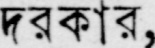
দরকার,
